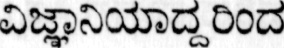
ವಿಜ್ಞಾನಿಯಾದ್ದರಿಂದ
